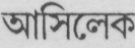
আসিলেক
